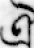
ঐ
